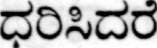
ಧರಿಸಿದರೆ
